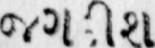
જગદીશ
